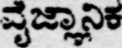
ವೈಜ್ಞಾನಿಕ
